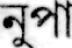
নুপা
